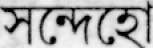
সন্দেহো
